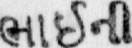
ભાઈની
